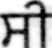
ਸੀ
